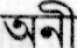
অনী
